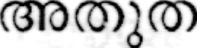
അതുത
